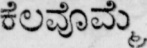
ಕೆಲವೊಮ್ಮೆ
